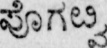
ಪೊಗೞ್ವ
